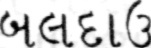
બલદાઉ
